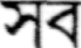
সব
